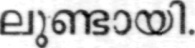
ലുണ്ടായി.
